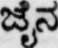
ಜೈನ
